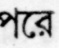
পরে
